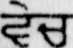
ਵੇਚ
